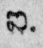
ಐ.
